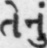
તેનું
